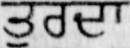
ਤੁਰਦਾ
